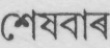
শেষবাৰ
